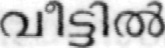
വീട്ടില്‍
